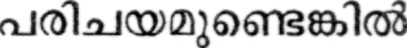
പരിചയമുണ്ടെങ്കില്‍
